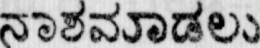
ನಾಶಮಾಡಲು
